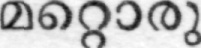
മറ്റൊരു
